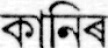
কানিৰ
